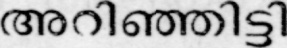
അറിഞ്ഞിട്ടി
